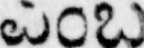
ಎಂಬ
